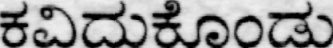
ಕವಿದುಕೊಂಡು
